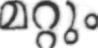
മറ്റും
